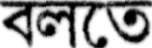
বলতে
